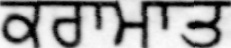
ਕਰਾਮਾਤ
